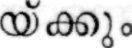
യ്ക്കും
